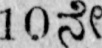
10ನೇ
